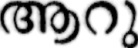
ആറു
